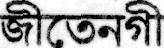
জীতেনগী
